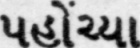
પહોંચ્યા
